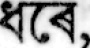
ধৰে,
